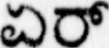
ಏರ್‌
